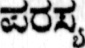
ಪರಸ್ಯ
